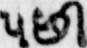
પછી
